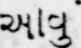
આવું
